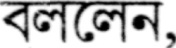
বললেন,
